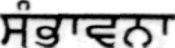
ਸੰਭਾਵਨਾ
